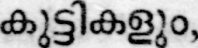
കുട്ടികളും,
